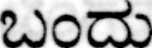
ಬಂದು
